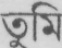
তুমি
